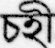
চহী
